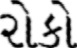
રોકો
